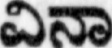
ವಿನಾ
